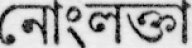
নোংলক্তা
